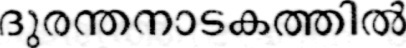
ദുരന്തനാടകത്തില്‍
